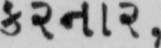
કરનાર,
